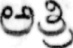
ಅತ್ರಿ
